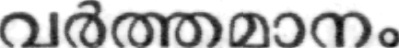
വര്‍ത്തമാനം
